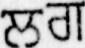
ਲਗ
